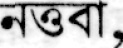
নত্তবা,
